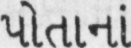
પોતાનાં
